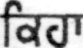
ਕਿਹਾ
